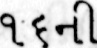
૧૬ની
